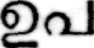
ഉപ
